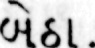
બેઠા.
